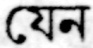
যেন
